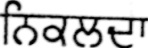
ਨਿਕਲਦਾ
